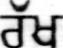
ਰੱਖ
